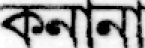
কনানা
